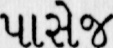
પાસેજ
